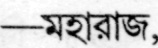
–মহারাজ,
